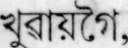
খুৱায়গৈ,
